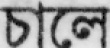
চালে
